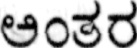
ಅಂತರ
